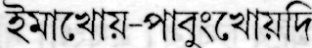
ইমাখোয়-পাবুংখোয়দি
